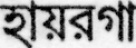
হায়রগা
